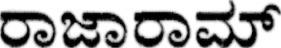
ರಾಜಾರಾಮ್
